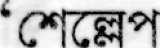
‘শেল্লেপ
